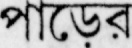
পাড়ের
